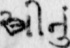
સ્ત્રીનું
